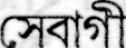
সেবাগী
